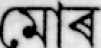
মোৰ
